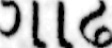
ગાઢ
